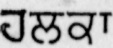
ਹਲਕਾ
